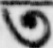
ত
